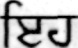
ਇਹ
